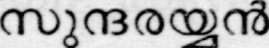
സുന്ദരയ്യന്‍
